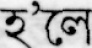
হ'লে
